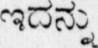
ಇದನ್ನು
